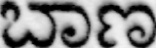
ಬಾಣ
